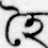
হৈ
